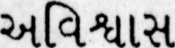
અવિશ્વાસ
